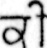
ਕੀ
